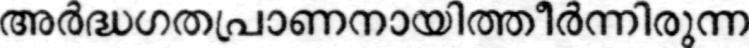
അര്‍ദ്ധഗതപ്രാണനായിത്തീര്‍ന്നിരുന്ന
